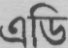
এড়ি
